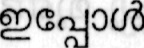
ഇപ്പോള്‍
